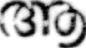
ആ
